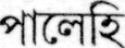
পালেহি
